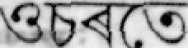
ওচৰতে
